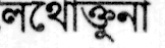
লৈথোক্তুনা
